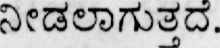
ನೀಡಲಾಗುತ್ತದೆ.
